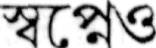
স্বপ্নেও
